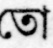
তো
